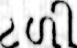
ટળી
